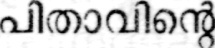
പിതാവിന്റെ
